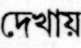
দেখায়
